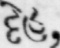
દેહ,
